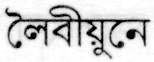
লৈবীয়ুনে
